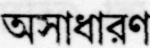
অসাধারণ
